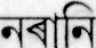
নৰানি
